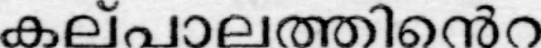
കല്പാലത്തിന്റെ
